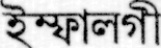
ইম্ফালগী
